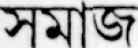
সমাজ
